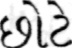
છોટે
